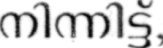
നിന്നിട്ട്,
